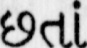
છતાં
